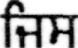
ਜਿਸ
